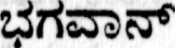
ಭಗವಾನ್
